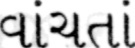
વાંચતાં
